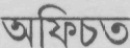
অফিচত
